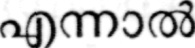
എന്നാല്‍
